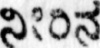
ನೀರಿನ
